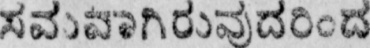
ಸಮವಾಗಿರುವುದರಿಂದ
